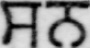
ਸਨ
